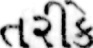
તરીકે
